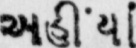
અહીંયા
